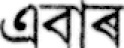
এবাৰ
